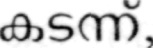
കടന്ന്,
